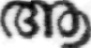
ആ
